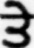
ਤੇ
